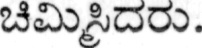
ಚಿಮ್ಮಿಸಿದರು.
